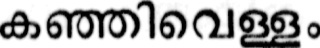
കഞ്ഞിവെള്ളം
